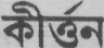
কীৰ্ত্তন
